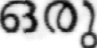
ഒരു
